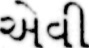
એવી
